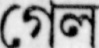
গেল
